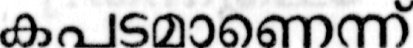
കപടമാണെന്ന്
